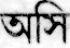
অসি
